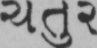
ચતુર
